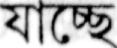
যাচ্ছে
